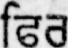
ਫਿਰ
